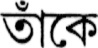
তাঁকে
